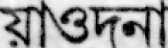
য়াওদনা
